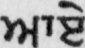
ਆਏ
